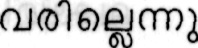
വരില്ലെന്നു
